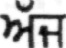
ਅੱਜ
